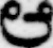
ಆ
